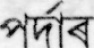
পর্দাৰ
